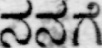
ನನಗೆ
